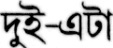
দুই-এটা
